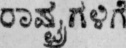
ರಾಷ್ಟ್ರಗಳಿಗೆ
